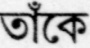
তাঁকে
